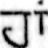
ਹਾਂ
